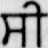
ਸੀ
